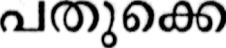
പതുക്കെ
